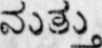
ಮತ್ತು
